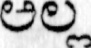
ಅಲ್ಲ
